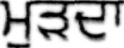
ਮੁੜਦਾ
